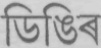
ডিঙিৰ
